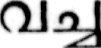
വച്ച
